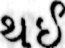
થઈ
